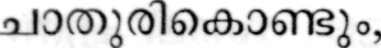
ചാതുരികൊണ്ടും,
